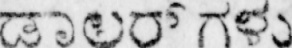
ಡಾಲರ್‌ಗಳು
